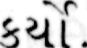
કર્યો.
